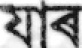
যাৰ
